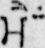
ਮੈਂ
